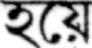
হয়ে
